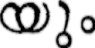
യും
